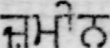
ਜ਼ਮੀਨ
